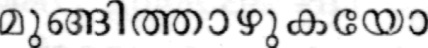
മുങ്ങിത്താഴുകയോ
